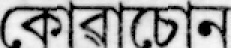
কোৱাচোন
